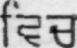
ਵਿਚ
